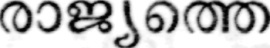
രാജ്യത്തെ
